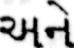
અને
